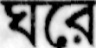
ঘরে
